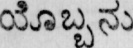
ಯೊಬ್ಬನು
